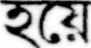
হয়ে
